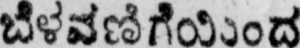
ಬೆಳವಣಿಗೆಯಿಂದ
